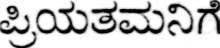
ಪ್ರಿಯತಮನಿಗೆ
